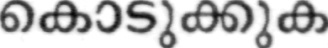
കൊടുക്കുക
